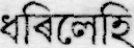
ধৰিলেহি
